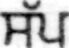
ਸੱਪ
